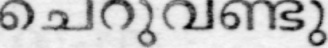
ചെറുവണ്ടു
